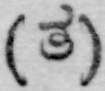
(ತ)
